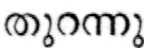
തുറന്നു
